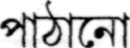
পাঠানো
